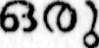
ഒരു
